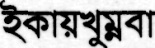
ইকায়খুম্নবা
